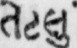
તેટલું
